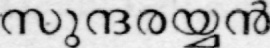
സുന്ദരയ്യന്‍
